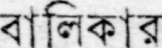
বালিকার
